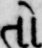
તો
